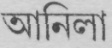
আনিলা
